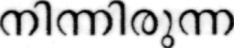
നിന്നിരുന്ന
